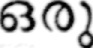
ഒരു
